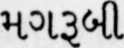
મગરૂબી
